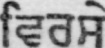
ਵਿਰਸੇ
